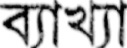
ব্যাখ্যা
